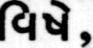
વિષે,
